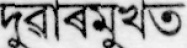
দুৱাৰমুখত
